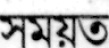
সময়ত
